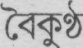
বৈকুণ্ঠ
